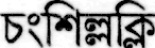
চংশিল্লক্লি
